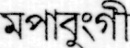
মপাবুংগী
